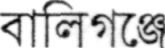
বালিগঞ্জে
